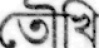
তৌখি
